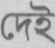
দেই
